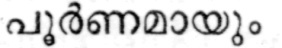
പൂര്‍ണമായും
